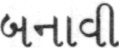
બનાવી
